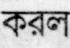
করল
